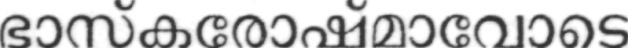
ഭാസ്കരോഷ്മാവോടെ
